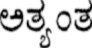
ಅತ್ಯಂತ
